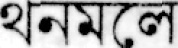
থনমলে
